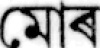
মোৰ
